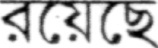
রয়েছে
